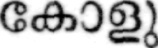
കോളു
